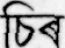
চিৰ
